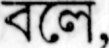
বলে,
